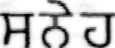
ਸਨੇਹ
